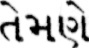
તેમણે
